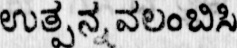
ಉತ್ಪನ್ನವಲಂಬಿಸಿ
